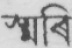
স্মৰি
